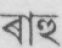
ৰাহু
